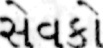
સેવકો
